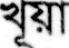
খূয়া
